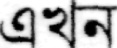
এখন
